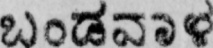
ಬಂಡವಾಳ
